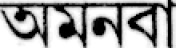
অমনবা
